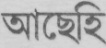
আছেহি
